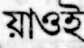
য়াওই
